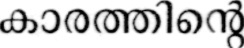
കാരത്തിന്റെ
